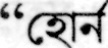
“হোর্ন
